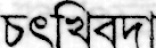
চৎখিবদা
